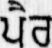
ਪੈਰ
